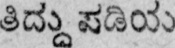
ತಿದ್ದುಪಡಿಯ
